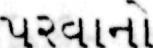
પરવાનો
